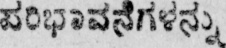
ಪರಿಭಾವನೆಗಳನ್ನು
